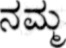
ನಮ್ಮ
